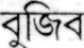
বুজিব
